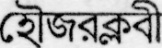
হৌজরক্লবী
